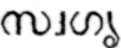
സ്വഗൃ
